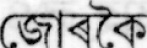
জোৰকৈ
